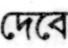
দেবে
